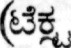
(ಟೆಕ್ಸ್ಟ
